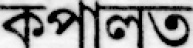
কপালত
